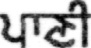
ਪਾਣੀ
